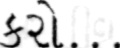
કરો...
